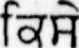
ਕਿਸੇ
